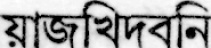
য়াজখিদবনি
